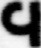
વ
